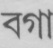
বগা
